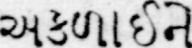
અકળાઈને
